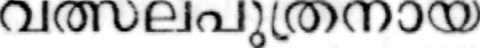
വത്സലപുത്രനായ
